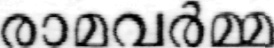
രാമവര്‍മ്മ
